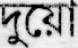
দুয়ো
